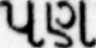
પણ
